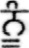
ਨੂੰ
